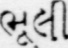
ભૂલી
